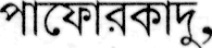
পাফোরকাদু,
